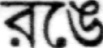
রঙে
